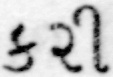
કરી
